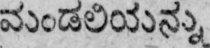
ಮಂಡಲಿಯನ್ನು
